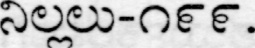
ನಿಲ್ಲಲು-೧೯೯.
